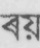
ৰয়
